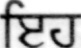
ਇਹ
